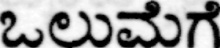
ಒಲುಮೆಗೆ
